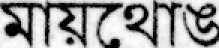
মায়থোঙ
